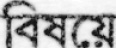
বিষয়ে
